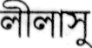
লীলাসু
